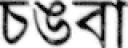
চঙবা
